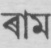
ৰাম
